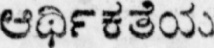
ಆರ್ಥಿಕತೆಯ
